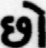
છો
